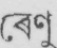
ৰেণু
